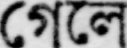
গেলে
